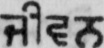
ਜੀਵਨ
